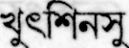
খুৎশিনসু
